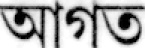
আগত
